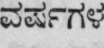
ವರ್ಷಗಳ
